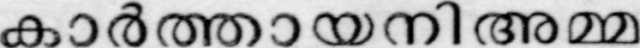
കാര്‍ത്തായനിഅമ്മ
